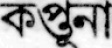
কপ্তুনা
